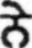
ਨੇ
